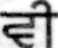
ਵੀ
